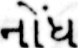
નોંધ
